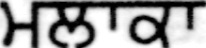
ਮਲਾਕਾ
